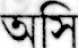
অসি
